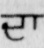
ਦਾ
